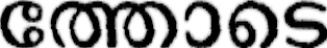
ത്തോടെ
